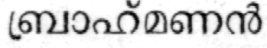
ബ്രാഹ്മണന്‍
